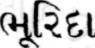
ભૂરિદા
